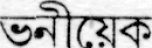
ভনীয়েক
